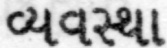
વ્યવસ્થા
